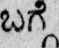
ಬಗ್ಗೆ
